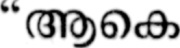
“ആകെ
